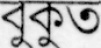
বুকুত
